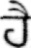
ਹੈ
